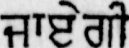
ਜਾਏਗੀ
